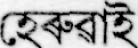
হেৰুৱাই
